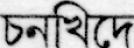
চনখিদে
